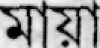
মায়া
